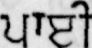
ਪਾਈ
